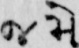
જમે
